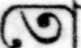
তো
